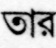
তার
